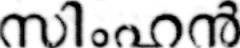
സിംഹന്‍
